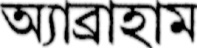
অ্যাব্রাহাম
